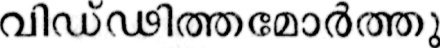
വിഡ്ഢിത്തമോര്‍ത്തു
